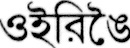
ওইরিঙৈ
